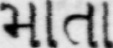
માતા
